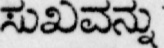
ಸುಖವನ್ನು
